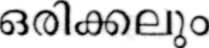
ഒരിക്കലും
